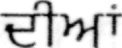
ਦੀਆਂ
